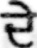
ਦੇ
